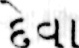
દેવા
